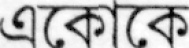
একোকে
